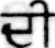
ਦੀ
